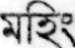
মহিং
